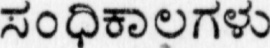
ಸಂಧಿಕಾಲಗಳು
